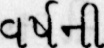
વર્ષની
